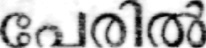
പേരില്‍
